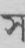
স
